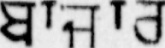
ਬਾਜਾਰ
